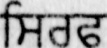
ਸਿਰਫ
